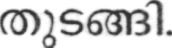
തുടങ്ങി.
